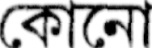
কোনো
